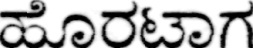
ಹೊರಟಾಗ
